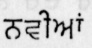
ਨਵੀਆਂ
